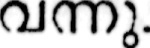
വന്നു.
